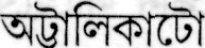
অট্টালিকাটো
